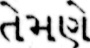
તેમણે
